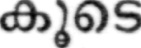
കൂടെ
